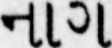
નાગ
